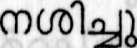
നശിച്ചു
